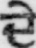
ਦੇ
